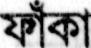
ফাঁকা
